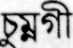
চুম্নগী
